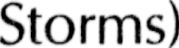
Storms)
